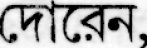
দোরেন,
